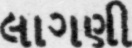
લાગણી
